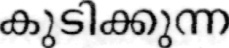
കുടിക്കുന്ന
